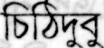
চিঠিদুবু
